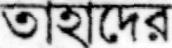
তাহাদের
